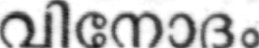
വിനോദം
